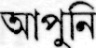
আপুনি
